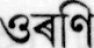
ওৰণি
